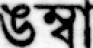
ঙম্বা
